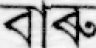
বাৰু
